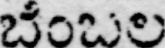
ಬೆಂಬಲ
